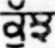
ਕੁੱਝ
